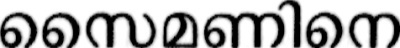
സൈമണിനെ
